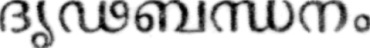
ദൃഢബന്ധനം
